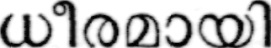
ധീരമായി
